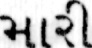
મારી
